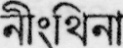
নীংথিনা
